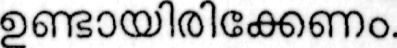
ഉണ്ടായിരിക്കേണം.
